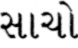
સાચો
